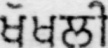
ਖੋਖਲੀ
